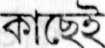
কাছেই
